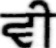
ਵੀ
